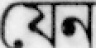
যেন
